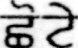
ਛੋਟੇ
